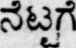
ನೆಟ್ಟಗೆ
